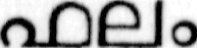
ഫലം
